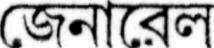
জেনারেল
